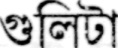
গুলিটা
